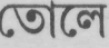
তোলে
